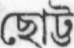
ছোট্ট
